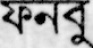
ফনবু
